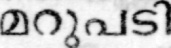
മറുപടി
